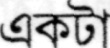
একটা
